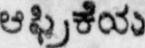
ಆಫ್ರಿಕೆಯ
